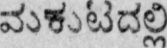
ಮಕುಟದಲ್ಲಿ
